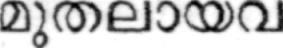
മുതലായവ
